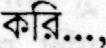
করি...,
